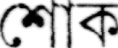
শোক
